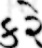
કરે
